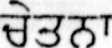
ਚੇਤਨਾ
